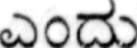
ಎಂದು
